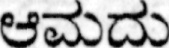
ಆಮದು
